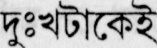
দুঃখটাকেই
